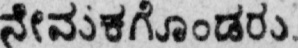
ನೇಮಕಗೊಂಡರು.
